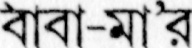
বাবা-মা’র
